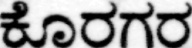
ಕೊರಗರ
